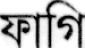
ফাগি
